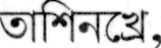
তাশিনখ্রে,
